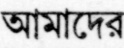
আমাদের
